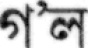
গ'ল
